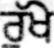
ਰੁੱਖੇ
